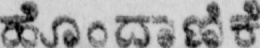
ಹೊಂದಾಣಿಕೆ
